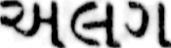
અલગ
